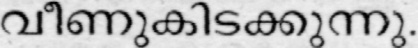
വീണുകിടക്കുന്നു.
